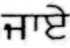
ਜਾਏ
